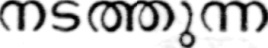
നടത്തുന്ന
